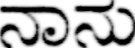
ನಾನು
